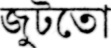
জুটতো
